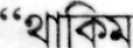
"থাকিম
